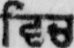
ਵਿਚ
